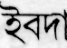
ইবদা
